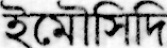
ইমৌসিদি
